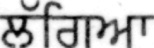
ਲੱਗਿਆ
